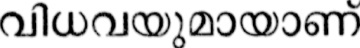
വിധവയുമായാണ്
